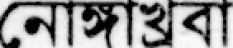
নোঙ্গাখ্রবা
